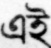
এই
